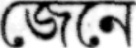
জেনে
